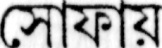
সোফায়
